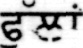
ਫੁੱਲਾਂ
